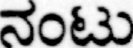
ನಂಟು
